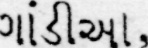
ગાંડીઆ,
